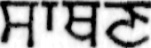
ਸਾਥਣ
